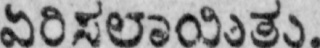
ಏರಿಸಲಾಯಿತು.
